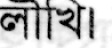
লৌখি।
